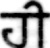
ਹੀ
